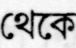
থেকে
